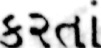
કરતાં
